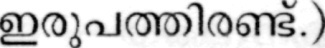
ഇരുപത്തിരണ്ട്.)
